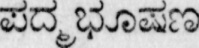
ಪದ್ಮಭೂಷಣ
